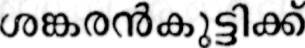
ശങ്കരന്‍കുട്ടിക്ക്
